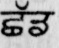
ਛੱਡ
